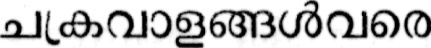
ചക്രവാളങ്ങള്‍വരെ
